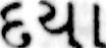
દયા
